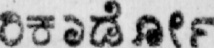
ರಿಕಾರ್ಡೋ
